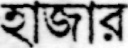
হাজার
